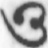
ও
